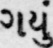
ગયું
